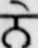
ਨੇ
